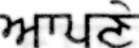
ਆਪਣੇ
